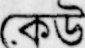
কেউ
